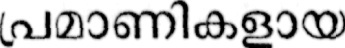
പ്രമാണികളായ
